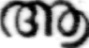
ആ
